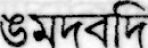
ঙমদবদি
